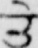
ਤੇ
